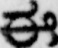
ಈ
